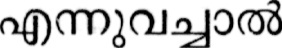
എന്നുവച്ചാല്‍
